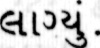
લાગ્યું.
